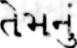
તેમનું
